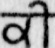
ਕੀ
